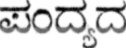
ಪಂದ್ಯದ
